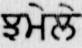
ਝਮੇਲੇ
